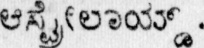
ಆಸ್ಟ್ರೇಲಾಯ್ಡ್.
